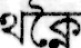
থক্নৈ
